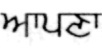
ਆਪਣਾ
